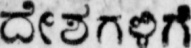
ದೇಶಗಳಿಗೆ
